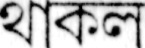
থাকল
